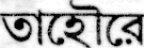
তাহৌরে
